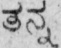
ತನ್ನ
